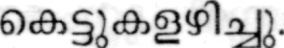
കെട്ടുകളഴിച്ചു.
